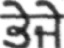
ਭੇਜੇ
